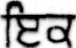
ਇਕ
